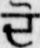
ਦੋ
